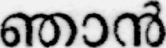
ഞാന്‍
